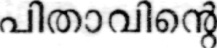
പിതാവിന്റെ
